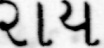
રાય
